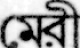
মেরী
